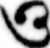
ও
